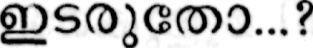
ഇടരുതോ...?
